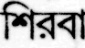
শিরবা
